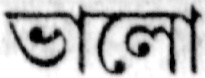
ভালো
